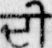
ਦੀ
